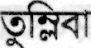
তুম্লিবা
